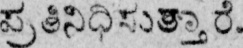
ಪ್ರತಿನಿಧಿಸುತ್ತಾರೆ.
